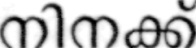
നിനക്ക്
